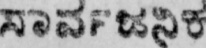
ಸಾರ್ವಜನಿಕ
